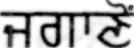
ਜਗਾਣੋਂ
